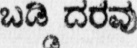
ಬಡ್ಡಿದರವು
